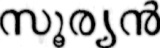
സൂര്യന്‍
